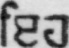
ਇਹ
